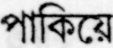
পাকিয়ে
